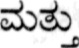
ಮತ್ತು
